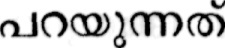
പറയുന്നത്
